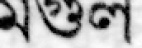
মগুল
